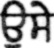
ਉਸੇ
